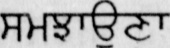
ਸਮਝਾਉਣਾ
